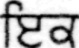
ਇਕ
